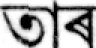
তাৰ
